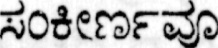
ಸಂಕೀರ್ಣವೂ
